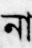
না
